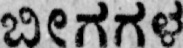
ಬೀಗಗಳ
